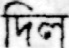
দিল
